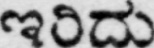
ಇರಿದು
